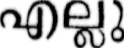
എല്ലു
